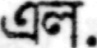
এল.
